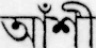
আঁশী
